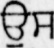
ਉਸ
